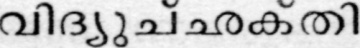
വിദ്യുച്ഛക്തി
